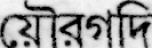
য়ৌরগদি
